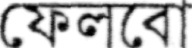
ফেলবো
